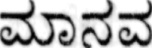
ಮಾನವ
